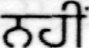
ਨਹੀਂ
